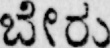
ಬೇರು
